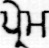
ਪ੍ਰੇਮ
